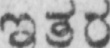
ಇತರ
